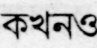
কখনও
